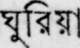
ঘুরিয়া
